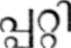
പ്പറ്റി
